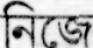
নিজে
